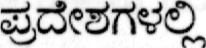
ಪ್ರದೇಶಗಳಲ್ಲಿ
